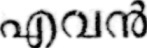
എവന്‍
